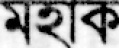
মহাক
